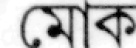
মোক
